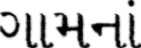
ગામનાં
